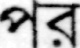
পর
